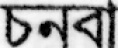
চনবা
